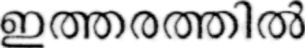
ഇത്തരത്തില്‍
